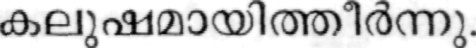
കലുഷമായിത്തീര്‍ന്നു.
